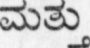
ಮತ್ತು
